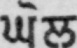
ਘੋਲ
